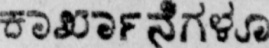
ಕಾರ್ಖಾನೆಗಳೂ
